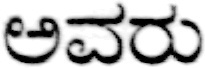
ಅವರು
